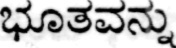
ಭೂತವನ್ನು
